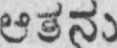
ಆತನು
